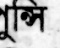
পুন্সি
